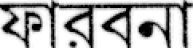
ফারবনা
